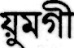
য়ুমগী
